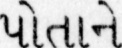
પોતાને
